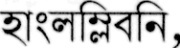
হাংলম্লিবনি,
